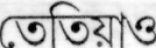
তেতিয়াও
